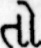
તો
